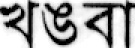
খঙবা
